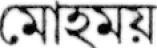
মোহময়
